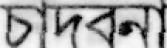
চাদবনা
